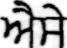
ਐਸੇ
